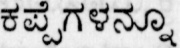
ಕಪ್ಪೆಗಳನ್ನೂ
